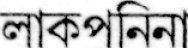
লাকপনিনা
